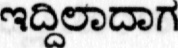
ಇದ್ದಿಲಾದಾಗ
